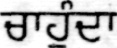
ਚਾਹੁੰਦਾ
